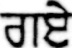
ਗਏ
